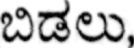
ಬಿಡಲು,
